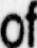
of
